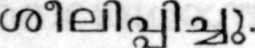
ശീലിപ്പിച്ചു.
